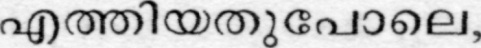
എത്തിയതുപോലെ,
